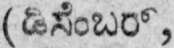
(ಡಿಸೆಂಬರ್,
